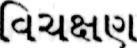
વિચક્ષણ
